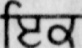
ਇਕ
